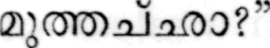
മുത്തച്ഛാ?"
